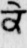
ਕੇ
